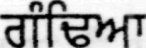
ਗੰਢਿਆ
